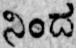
ನಿಂದ
